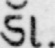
ડૉ.
